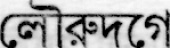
লৌরুদগে
